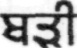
ਬੜੀ
